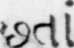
છતાં
